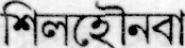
শিলহৌনবা
